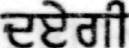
ਦਏਗੀ
